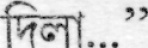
দিলা..."
